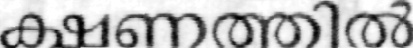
ക്ഷണത്തില്‍
